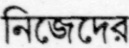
নিজেদের
